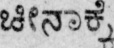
ಚೀನಾಕ್ಕೆ
